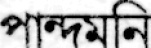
পান্দমনি
